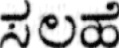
ಸಲಹೆ
